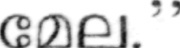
മേല."
